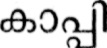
കാപ്പി
